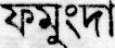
ফমুংদা
